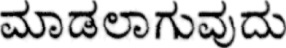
ಮಾಡಲಾಗುವುದು
